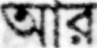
আর
